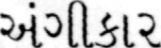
અંગીકાર
